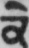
ਕੇ
